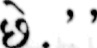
છે."
